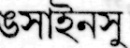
ঙসাইনসু
